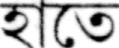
হাতে
